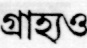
গ্রাহ্যও
